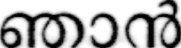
ഞാന്‍
